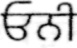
ਓਨੀ
